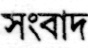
সংবাদ
